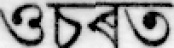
ওচৰত
